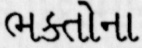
ભક્તોના
